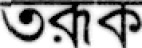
তরূক
